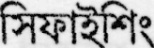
সিফাইশিং
